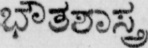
ಭೌತಶಾಸ್ತ್ರ
